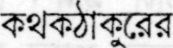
কথকঠাকুরের
